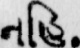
નહિ.
